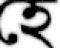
হে
